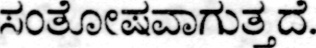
ಸಂತೋಷವಾಗುತ್ತದೆ.
